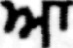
ਆ
